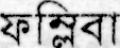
ফম্লিবা
